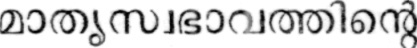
മാതൃസ്വഭാവത്തിന്റെ
